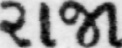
રાજા
